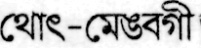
থোৎ-মেঙবগী
